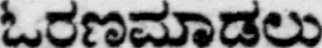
ಓರಣಮಾಡಲು
